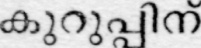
കുറുപ്പിന്
